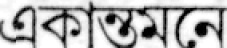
একান্তমনে
